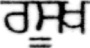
ਰਸੂਖ
